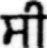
ਸੀ
